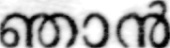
ഞാന്‍
